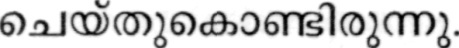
ചെയ്തുകൊണ്ടിരുന്നു.
